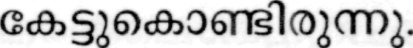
കേട്ടുകൊണ്ടിരുന്നു.
